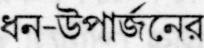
ধন-উপার্জনের
